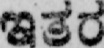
ಇತರ
